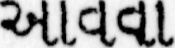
આવવા
